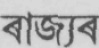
ৰাজ্যৰ
